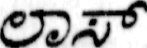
ಲಾಸ್
